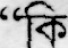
"কি
